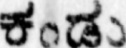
ಕಂಡು
